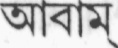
আবাম্
